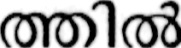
ത്തില്‍
